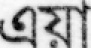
এয়া
